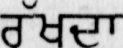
ਰੱਖਦਾ
